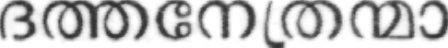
ദത്തനേത്രന്മാ
